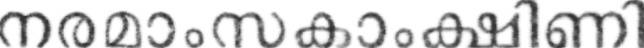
നരമാംസകാംക്ഷിണി
